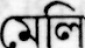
মেলি
